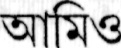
আমিও
